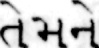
તેમને
